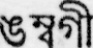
ঙম্বগী
